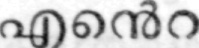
എന്റെ
